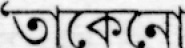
'তাকেনো
